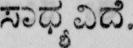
ಸಾಧ್ಯವಿದೆ.
